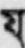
য
